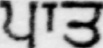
ਪਾਤ
